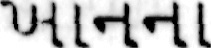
ખાનના
